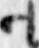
ન
